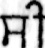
ਸੀ
